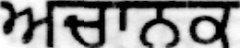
ਅਚਾਨਕ
